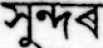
সুন্দৰ
